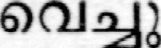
വെച്ചു
